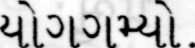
યોગગમ્યો.
